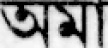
অমা
